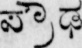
ಪ್ರೌಢ
